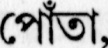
পোঁতা,
